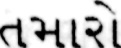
તમારો
